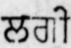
ਲਗੀ
